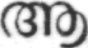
ആ
